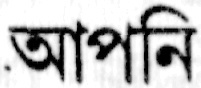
আপনি
